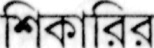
শিকারির
